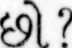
છો?
